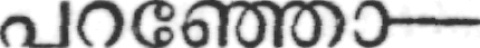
പറഞ്ഞോ-
